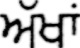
ਅੱਖਾਂ
